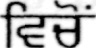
ਵਿਚੋਂ
